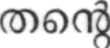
തന്റെ
